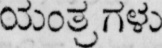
ಯಂತ್ರಗಳು
